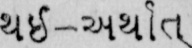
થઈ-અર્થાત્
